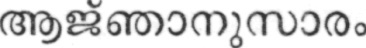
ആജ്ഞാനുസാരം
